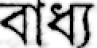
বাধ্য
